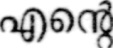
എന്റെ
